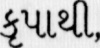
કૃપાથી,
